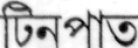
টিনপাত
